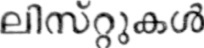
ലിസ്റ്റുകള്‍
